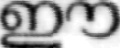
ഈ
